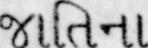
જાતિના
